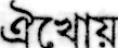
ইখোয়
